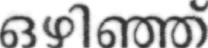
ഒഴിഞ്ഞ്
